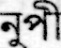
নুপী
